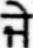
ਜੇ
